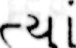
ત્યાં
